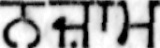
ਨਜ਼ਾਮ
